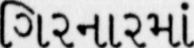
ગિરનારમાં
